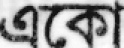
একো
